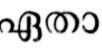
ഏതാ
